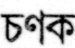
চণক
